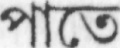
পাতে
